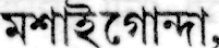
মশাইগোন্দা,
